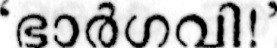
‘ഭാര്‍ഗവി!’
